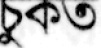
চুকত
